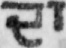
ਦਾ
